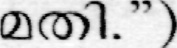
മതി.'')
